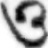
ও
